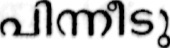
പിന്നീടു
